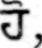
ਹੋ,
